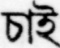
চাই
